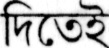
দিতেই
